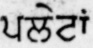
ਪਲੇਟਾਂ
